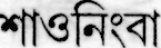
শাওনিংবা
